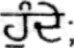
ਹੁੰਦੇ;
